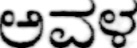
ಅವಳ
